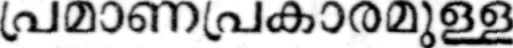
പ്രമാണപ്രകാരമുള്ള
